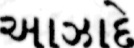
આઝાદે
